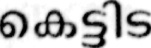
കെട്ടിട
